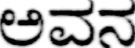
ಅವನ
